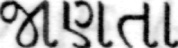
જાણતા
